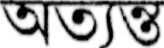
অত্যন্ত
